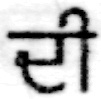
ਦੀ
